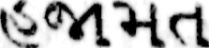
હજામત
